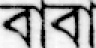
বাবা
